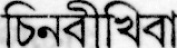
চিনবীখিবা
